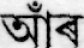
আঁৰ
